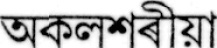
অকলশৰীয়া
